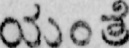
ಯಂತೆ
